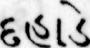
દહાડે
